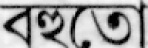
বহুতো
